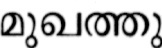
മുഖത്തു
